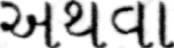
અથવા
